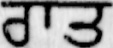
ਰਾਤ
